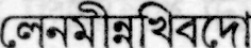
লেনমীন্নখিবদো
